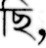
ছি,
